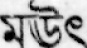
মঊৎ
